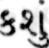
કશું
